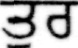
ਤੁਰ
